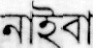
নাইবা
